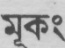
মূকং
